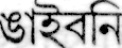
ঙাইবনি
